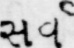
સર્વ
